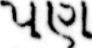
પણ
